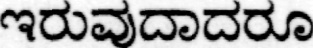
ಇರುವುದಾದರೂ
